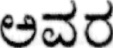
ಅವರ
